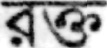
রক্ত
